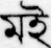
মই
